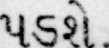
પડશે.
